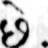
છે.
